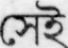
সেই
